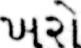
ખરો
